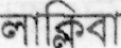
লাক্লিবা
